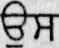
ਉਸ
